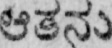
ಆತನು
